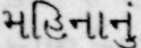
મહિનાનું
